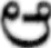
ಆ
